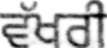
ਵੱਖਰੀ
